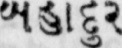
બહાદુર
